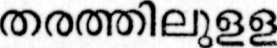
തരത്തിലുള്ള
